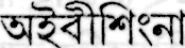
অইবীশিংনা
